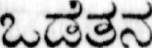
ಒಡೆತನ
